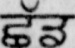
ਛੱਡ
